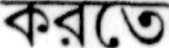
করতে
